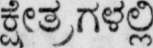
ಕ್ಷೇತ್ರಗಳಲ್ಲಿ
